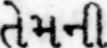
તેમની
